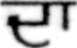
ਦਾ
